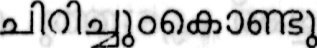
ചിറിച്ചുംകൊണ്ടു
